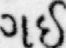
ગઈ
